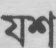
যশ
